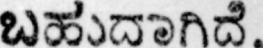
ಬಹುದಾಗಿದೆ.
